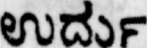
ಉರ್ದು
